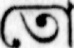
তো
